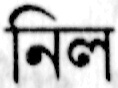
নিল
